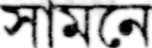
সামনে
